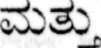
ಮತ್ತು
